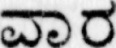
ವಾರ
